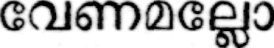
വേണമല്ലോ
